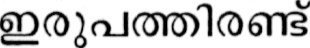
ഇരുപത്തിരണ്ട്
